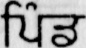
ਪਿੰਡ
